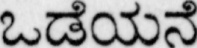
ಒಡೆಯನೆ
